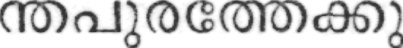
ന്തപുരത്തേക്കു
